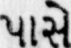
પાસે
